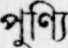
পুণ্যি
